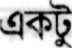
একটু
